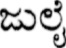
ಜುಲೈ
